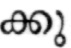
ക്കു
